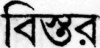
বিস্তর
